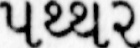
પથ્થર
